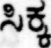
ಸಿಕ್ಕ
